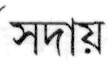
সদায়
